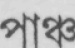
পাঞ্চ
